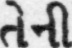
તેની
